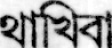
থাখিবা
